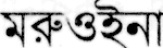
মরুওইনা
